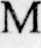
M
